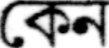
কেন
